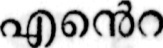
എന്റെ
